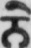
ਨੇ
